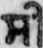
ਸੀ
